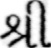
શ્રી
